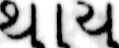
થાય
